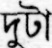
দুটা
